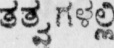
ತತ್ವಗಳಲ್ಲಿ
